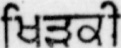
ਖਿੜਕੀ
